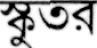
স্কুতর
